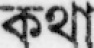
কথা
